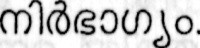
നിര്‍ഭാഗ്യം.
